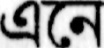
এনে
